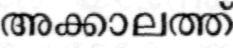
അക്കാലത്ത്
